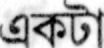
একটা
